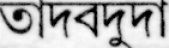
তাদবদুদা
